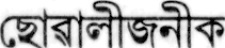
ছোৱালীজনীক
